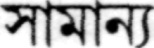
সামান্য
